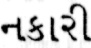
નકારી
